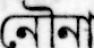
নৌনা
